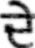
ਦੇ
